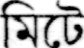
মিটে
